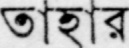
তাহার
